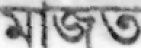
মাজত
